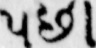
પછી
